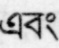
এবং
